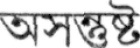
অসন্তুষ্ট
